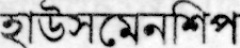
হাউসমেনশিপ
